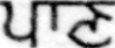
ਪਾਣ
